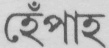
হেঁপাহ
